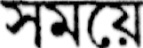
সময়ে
